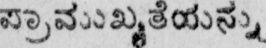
ಪ್ರಾಮುಖ್ಯತೆಯನ್ನು
